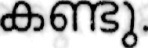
കണ്ടു.
